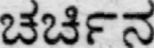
ಚರ್ಚಿನ
